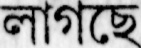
লাগছে
